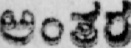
ಅಂತರ
